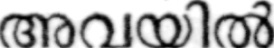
അവയില്‍
